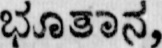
ಭೂತಾನ,
